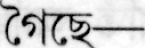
গৈছে-
